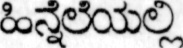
ಹಿನ್ನೆಲೆಯಲ್ಲಿ
